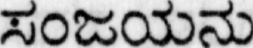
ಸಂಜಯನು
